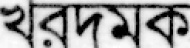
খরদমক
